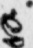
હું
